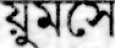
য়ুমসে
